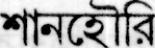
শানহৌরি
